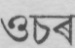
ওচৰ
